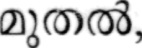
മുതല്‍,
